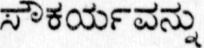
ಸೌಕರ್ಯವನ್ನು
